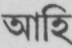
আহি
